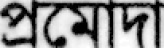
প্রমোদা
